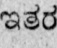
ಇತರ
